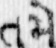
તમે
